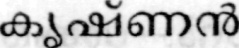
കൃഷ്ണന്‍
